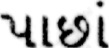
પાછાં
